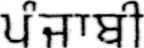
ਪੰਜਾਬੀ
